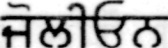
ਜੋਲੀਓਨ
